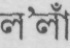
ল'লাঁ
